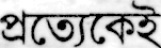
প্রত্যেকেই
